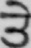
ਤੇ
